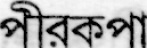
পীরকপা
